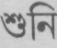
শুনি
